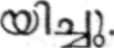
യിച്ചു.
